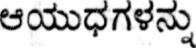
ಆಯುಧಗಳನ್ನು
